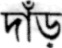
দাঁড়
